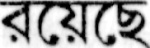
রয়েছে
